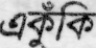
একুঁকি
